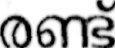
രണ്ട്
